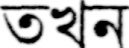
তখন
